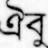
ঐবু
